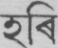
হৰি
